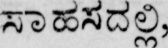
ಸಾಹಸದಲ್ಲಿ,
